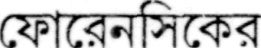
ফোরেনসিকের
